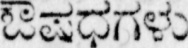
ಔಷಧಗಳು
